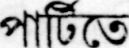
পার্টিতে
